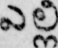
ಎಲ್ಲಿ
